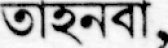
তাহনবা,
